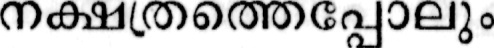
നക്ഷത്രത്തെപ്പോലും
